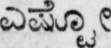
ಎಷ್ಟೋ
